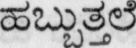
ಹಬ್ಬುತ್ತಲೆ
